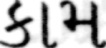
કામ
